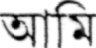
আমি
